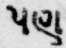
પણ
